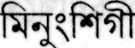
মিনুংশিগী
